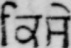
ਕਿਸੇ
